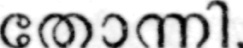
തോന്നി.
